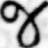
જ
